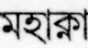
মহাক্না
